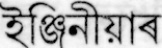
ইঞ্জিনীয়াৰ
